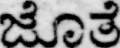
ಜೊತೆ
